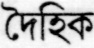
দৈহিক
